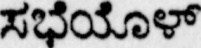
ಸಭೆಯೊಳ್
